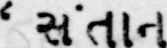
'સંતાન
